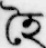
হৈ
